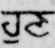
ਹੁਣ
